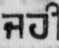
ਜਹੀ
